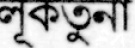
লূকতুনা
